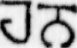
ਹਨ
